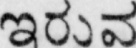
ಇರುವ
